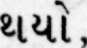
થયો,
